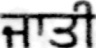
ਜਾਤੀ
